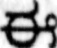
ಈ
